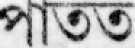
পাতত
